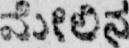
ಮೇಲಿನ
